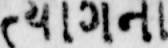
ત્યાગના
